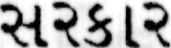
સરકાર
